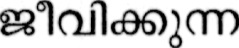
ജീവിക്കുന്ന
